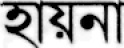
হায়না
